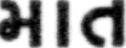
માત
